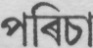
পৰিচা
